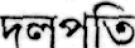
দলপতি
